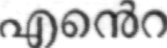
എന്റെ
